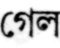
গেল
